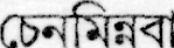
চেনমিন্নবা
